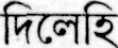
দিলেহি
